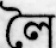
লৈ
